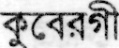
কুবেরগী
